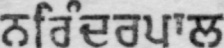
ਨਰਿੰਦਰਪਾਲ
